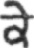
ਕੇ
